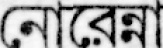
নোরেন্না
